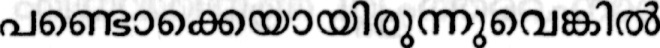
പണ്ടൊക്കെയായിരുന്നുവെങ്കില്‍
